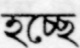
হচ্ছে
